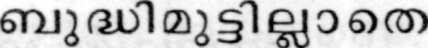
ബുദ്ധിമുട്ടില്ലാതെ
